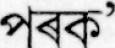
পৰক'
